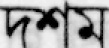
দশম
